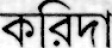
করিদা
